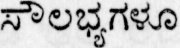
ಸೌಲಭ್ಯಗಳೂ
